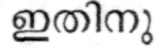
ഇതിനു
